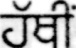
ਹੱਥੀਂ
